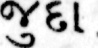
જુદા
